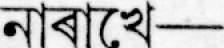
নাৰাখে-
